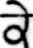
ਕੇ
